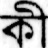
কী
